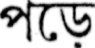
পড়ে
